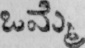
ಒಮ್ಮೆ
